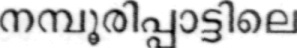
നമ്പൂരിപ്പാട്ടിലെ
